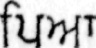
ਪਿਆ
